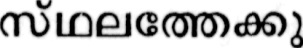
സ്ഥലത്തേക്കു
